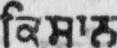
ਕਿਸਾਨ
